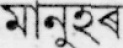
মানুহৰ
